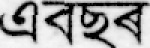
এবছৰ
